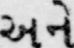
અને
